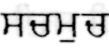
ਸਚਮੁਚ
